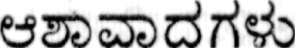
ಆಶಾವಾದಗಳು
